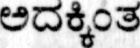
ಅದಕ್ಕಿಂತ
